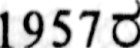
1957ರ
